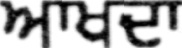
ਆਖਦਾ
